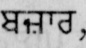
ਬਜ਼ਾਰ,
